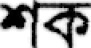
শক
